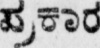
ಪ್ರಕಾರ
